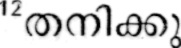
12തനിക്കു
